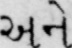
અને
